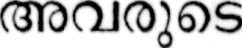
അവരുടെ
